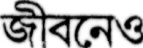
জীবনেও
